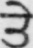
ਤੇ
